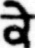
ਕੇ
